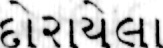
દોરાયેલા
